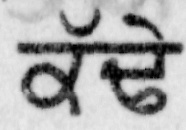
ਕੱਢੇ
